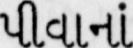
પીવાનાં
